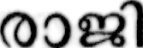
രാജി
